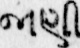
જાણી
